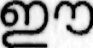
ഈ
